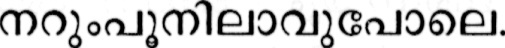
നറുംപൂനിലാവുപോലെ.
